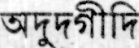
অদুদগীদি
